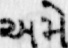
અમે
